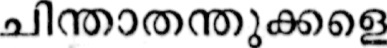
ചിന്താതന്തുക്കളെ
